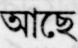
আছে
